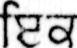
ਇਕ
